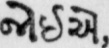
જોઈએ
